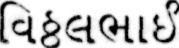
વિઠ્ઠલભાઈ
